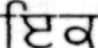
ਇਕ
